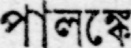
পালঙ্কে
